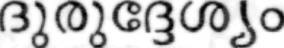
ദുരുദ്ദേശ്യം
